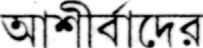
আশীর্বাদের
